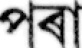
পৰা
